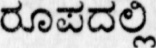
ರೂಪದಲ್ಲಿ
